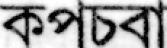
কপচবা
